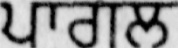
ਪਾਗਲ
